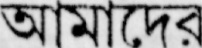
আমাদের
